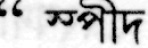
“স্পীদ
